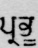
ਪ੍ਰਭੂ
